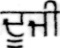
ਦੂਜੀ
